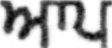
ਆਪ
